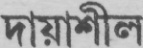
দায়াশীল
